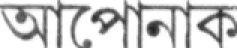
আপোনাক
